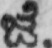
ಜೆ.
